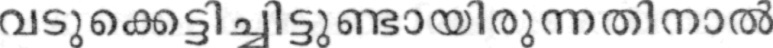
വടുക്കെട്ടിച്ചിട്ടുണ്ടായിരുന്നതിനാല്‍
